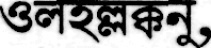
ওলহল্লক্কনু,
